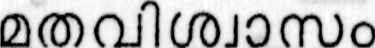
മതവിശ്വാസം
